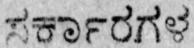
ಸರ್ಕಾರಗಳ
